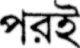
পরই
